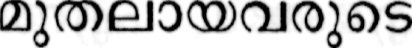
മുതലായവരുടെ
